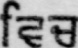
ਵਿਚ
